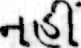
નહીં
